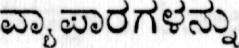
ವ್ಯಾಪಾರಗಳನ್ನು
